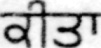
ਕੀਤਾ
